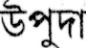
উপুদা
